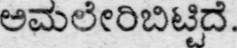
ಅಮಲೇರಿಬಿಟ್ಟಿದೆ.
